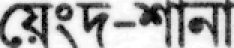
য়েংদ-শানা
